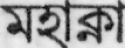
মহাক্না
